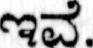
ಇವೆ.
